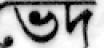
ভেদ
